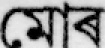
মোৰ
